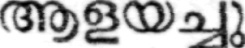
ആളയച്ചു
